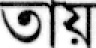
তায়
